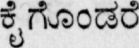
ಕೈಗೊಂಡರೆ
